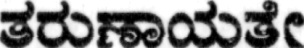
ತರುಣಾಯತೇ
